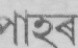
পাহৰ
